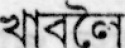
খাবলৈ
